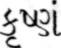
કૃષ્ણં
